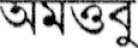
অমত্তবু
